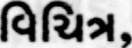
વિચિત્ર,
